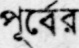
পূর্বের
